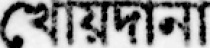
খোয়দানা
